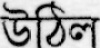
উঠিল
